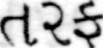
તરફ
